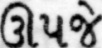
ઊપજે
